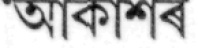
আকাশৰ
